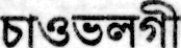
চাওভলগী
